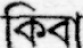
কিবা
